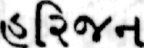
હરિજન
